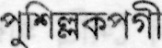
পুশিল্লকপগী
